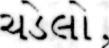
ચડેલો,
